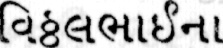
વિઠ્ઠલભાઈના
